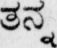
ತನ್ನ
